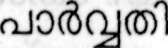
പാര്‍വ്വതി
